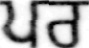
ਪਰ
